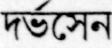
দর্ভসেন
